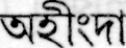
অহীংদা
